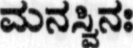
ಮನಸ್ವಿನಃ
